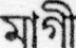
মাগী
